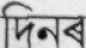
দিনৰ
